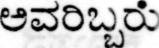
ಅವರಿಬ್ಬರು
